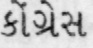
કોંગ્રેસ
